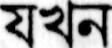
যখন
